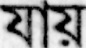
যায়
